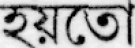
হয়তো
